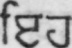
ਇਹ
